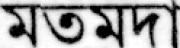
মতমদা
